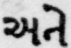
અને
